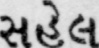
સહેલ
